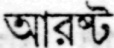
আরষ্ট
